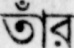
তাঁর
